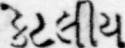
કેટલીય
